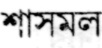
শাসমল
